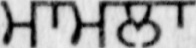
ਮਾਮਲਾ
